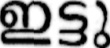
ഇട്ടു
